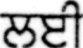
ਲਈ
